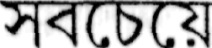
সবচেয়ে
